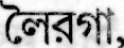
লৈরগা,
